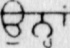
ਉਨ੍ਹਾਂ
